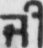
ਜੀ
